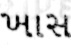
ખાસ
